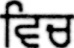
ਵਿਚ
